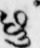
છું
